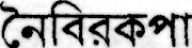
নৈবিরকপা
